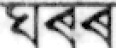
ঘৰৰ
